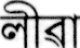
লীৱা
